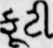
ફૂટી
